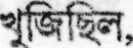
খুজিছিল,
